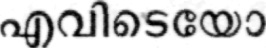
എവിടെയോ
